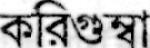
করিগুম্বা
